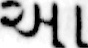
આ
